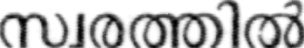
സ്വരത്തില്‍
